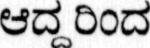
ಆದ್ದರಿಂದ
